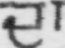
ਦਾ
